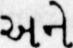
અને
